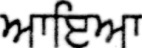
ਆਇਆ
